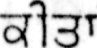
ਕੀਤਾ
